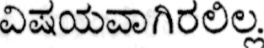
ವಿಷಯವಾಗಿರಲಿಲ್ಲ.
